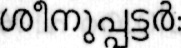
ശീനുപ്പട്ടര്‍:
